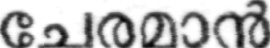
ചേരമാന്‍
